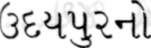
ઉદયપુરનો
